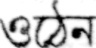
ওঠেন
